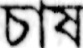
চাষ
